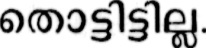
തൊട്ടിട്ടില്ല.
